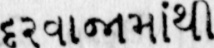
દરવાજામાંથી
